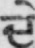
ਦੇ
